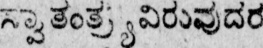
ಸ್ವಾತಂತ್ರ್ಯವಿರುವುದರ
